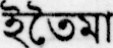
ইতৈমা
